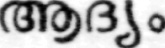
ആദ്യം
